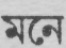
মনে
